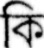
কি
